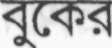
বুকের
